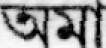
অমা
